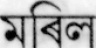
মৰিল
